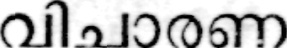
വിചാരണ
